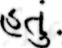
હતું.
